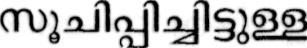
സൂചിപ്പിച്ചിട്ടുള്ള
